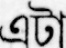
এটা
